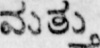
ಮತ್ತು
